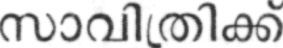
സാവിത്രിക്ക്
